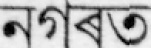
নগৰত
